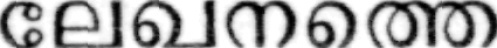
ലേഖനത്തെ
